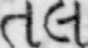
તલ
